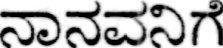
ನಾನವನಿಗೆ
